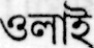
ওলাই
